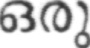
ഒരു
